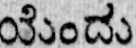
ಯೆಂದು
